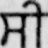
ਸੀ
